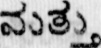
ಮತ್ತು
